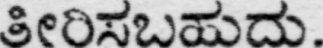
ತೀರಿಸಬಹುದು.
